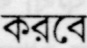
করবে
